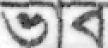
ভাব
